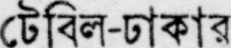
টেবিল-ঢাকার
